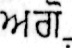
ਅਗੋ
